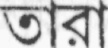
তারা
